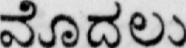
ಮೊದಲು
